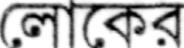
লোকের
